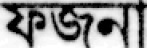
ফজনা
